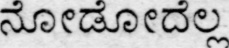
ನೋಡೋದೆಲ್ಲ
